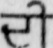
ਦੀ
